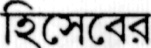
হিসেবের
